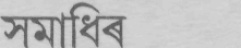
সমাধিৰ
